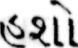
હશો
